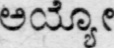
ಅಯ್ಯೋ
